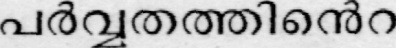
പര്‍വ്വതത്തിന്റെ
